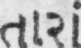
તારાં
